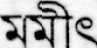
মমীৎ
